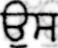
ਉਸ
